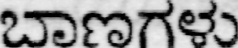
ಬಾಣಗಳು
